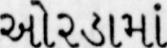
ઓરડામાં
